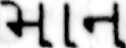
માન
